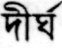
দীর্ঘ
